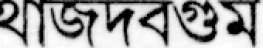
থাজদবগুম
